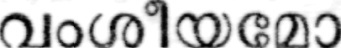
വംശീയമോ
